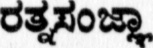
ರತ್ನಸಂಜ್ಞಾ
